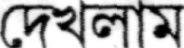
দেখলাম
